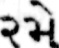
રમે
